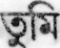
তুমি
